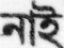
নাই
